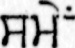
ਸਮੇਂ
